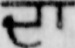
ਦਾ
